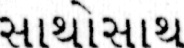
સાથોસાથ
